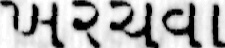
ખરચવા
